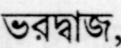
ভরদ্বাজ,
